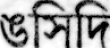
ঙসিদি
